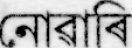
নোৱাৰি
